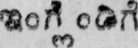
ಇಂಗ್ಲೆಂಡಿಗೆ
